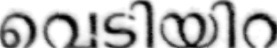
വെടിയിറ
